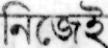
নিজেই
